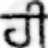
ਹੀ
